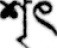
শৃৎ
